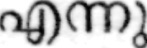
എന്നു
